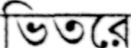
ভিতরে
